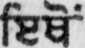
ਇਥੋਂ
